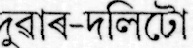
দুৱাৰ-দলিটো
